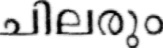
ചിലരും
